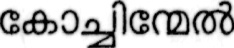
കോച്ചിന്മേല്‍
